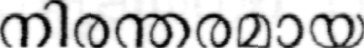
നിരന്തരമായ
